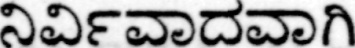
ನಿರ್ವಿವಾದವಾಗಿ
